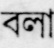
বলা
